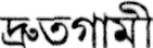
দ্ৰুতগামী
